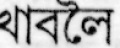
খাবলৈ
